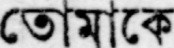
তোমাকে
